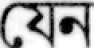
যেন
